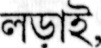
লড়াই,
